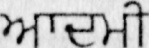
ਆਦਮੀ
